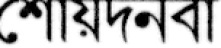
শোয়দনবা
